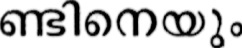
ണ്ടിനെയും
